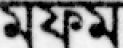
মফম
